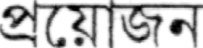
প্রয়োজন
